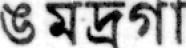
ঙমদ্রগা
